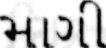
માગી
